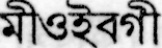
মীওইবগী
